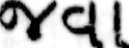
જવા
